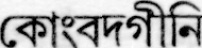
কোংবদগীনি
